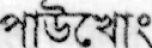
পাউখোং
